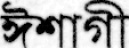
ঈশাগী
